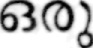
ഒരു
